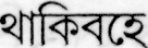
থাকিবহে
